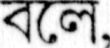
বলে,
